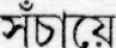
সঁচায়ে
